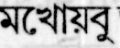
মখোয়বু
